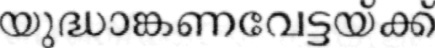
യുദ്ധാങ്കണവേട്ടയ്ക്ക്
